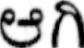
ಆಗಿ
